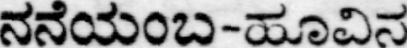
ನನೆಯಂಬ-ಹೂವಿನ
